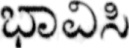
ಭಾವಿಸಿ
